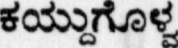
ಕಯ್ದುಗೊಳ್ವ
